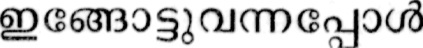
ഇങ്ങോട്ടുവന്നപ്പോള്‍
